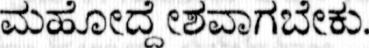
ಮಹೋದ್ದೇಶವಾಗಬೇಕು.
